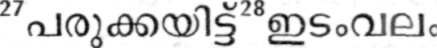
27പരുക്കയിട്ട്28ഇടംവലം
